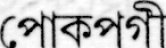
পোকপগী
